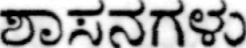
ಶಾಸನಗಳು
